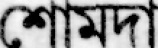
শোমদা
